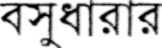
বসুধারার
